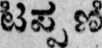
ಟಿಪ್ಪಣಿ
